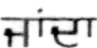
ਜਾਂਦਾ
